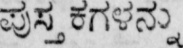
ಪುಸ್ತಕಗಳನ್ನು
